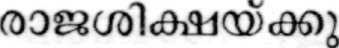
രാജശിക്ഷയ്ക്കു
